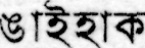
ঙাইহাক
